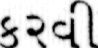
કરવી
